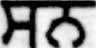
ਸਨ
